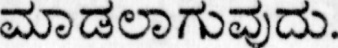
ಮಾಡಲಾಗುವುದು.
